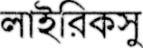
লাইরিকসু
